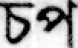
চপ
